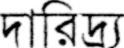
দারিদ্র্য
